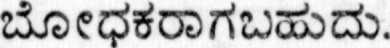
ಬೋಧಕರಾಗಬಹುದು.
